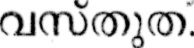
വസ് തുത
